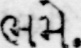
ભમે.
